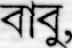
বাবু,
